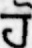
ਹੋ
